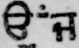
ਉਂਜ
